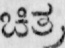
ಚಿತ್ರ
